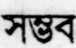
সম্ভব
